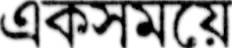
একসময়ে
